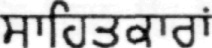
ਸਾਹਿਤਕਾਰਾਂ
